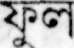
ফুল
